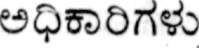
ಅಧಿಕಾರಿಗಳು
